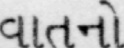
વાતનો
